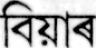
বিয়াৰ
